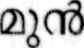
മുന്‍
